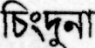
চিংদুনা
